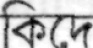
কিদে
